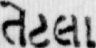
તેટલા
